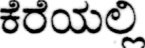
ಕೆರೆಯಲ್ಲಿ
